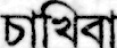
চাখিবা
